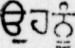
ਉਹਨੂੰ
